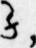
કે,
